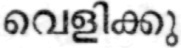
വെളിക്കു
